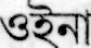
ওইনা
